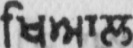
ਖਿਆਲ
